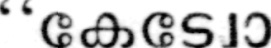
"കേട്വോ
